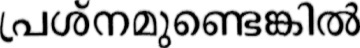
പ്രശ്നമുണ്ടെങ്കില്‍
